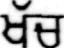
ਖੱਚ
